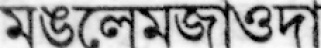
মঙলেমজাওদা
